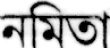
নমিতা
